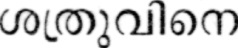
ശത്രുവിനെ
